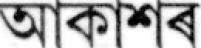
আকাশৰ
